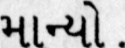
માન્યો.
